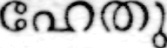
ഹേതു
